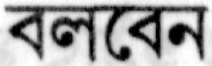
বলবেন
